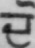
ਦੋ
